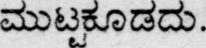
ಮುಟ್ಟಕೂಡದು.
